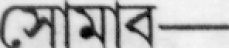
সোমাব-
